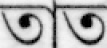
তাত
